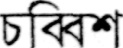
চব্বিশ
